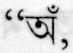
"অঁ,
